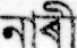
নাৰী
